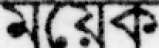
ময়েক
